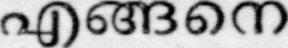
എങ്ങനെ
